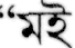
"মই
